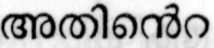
അതിന്റെ
